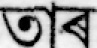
তাৰ
